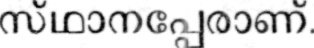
സ്ഥാനപ്പേരാണ്.
